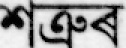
শত্রুৰ
